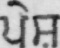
ਪੇਸ਼
